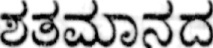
ಶತಮಾನದ
